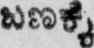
ಬುಣಕ್ಕೆ
